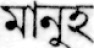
মানুহ
